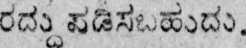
ರದ್ದುಪಡಿಸಬಹುದು.
